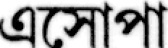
এসোপা
